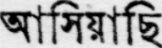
আসিয়াছি
